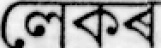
লেকৰ
